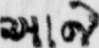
આજે
